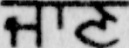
ਜਾਣ
